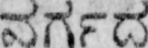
ವರ್ಗದ
